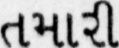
તમારી
